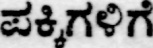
ಪಕ್ಕಿಗಳಿಗೆ
